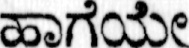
ಹಾಗೆಯೇ
